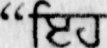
''ਇਹ
